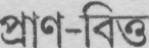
প্ৰাণ-বিত্ত
